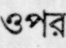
ওপর
